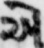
એ
